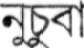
নুচুবা
